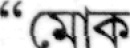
"মোক
